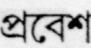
প্রবেশ
